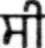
ਸੀ
